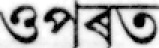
ওপৰত
